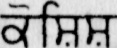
ਕੋਸ਼ਿਸ਼
